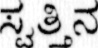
ಸ್ವತ್ತಿನ
